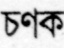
চণক
